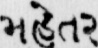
મહેતર
